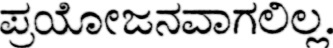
ಪ್ರಯೋಜನವಾಗಲಿಲ್ಲ.
